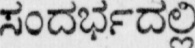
ಸಂದರ್ಭದಲ್ಲಿ
